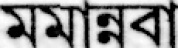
মমান্নবা
